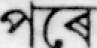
পৰে
